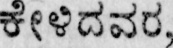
ಕೇಳಿದವರ,
